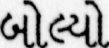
બોલ્યો
